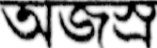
অজস্র
